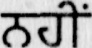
ਨਹੀਂ
